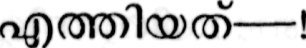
എത്തിയത്-!
